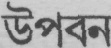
উপবন
